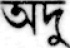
অদু
